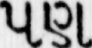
પણ
